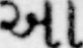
આ
